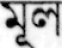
মূল
